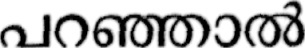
പറഞ്ഞാല്‍
